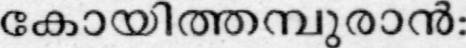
കോയിത്തമ്പുരാന്‍:
